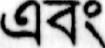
এবং
